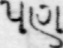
પણ
